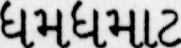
ધમધમાટ
